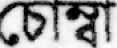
চোম্বা
